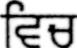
ਵਿਚ
